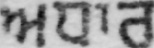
ਅਧਾਰ
